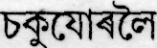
চকুযোৰলৈ
